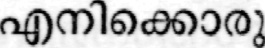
എനിക്കൊരു
